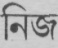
নিজ
